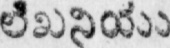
ಲೆಖನಿಯು
